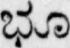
ಭೂ
